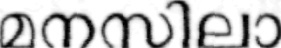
മനസിലാ
